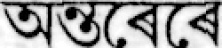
অন্তৰেৰে
